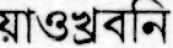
য়াওখ্রবনি
